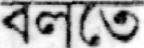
বলতে
